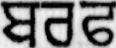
ਬਰਫ
